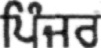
ਪਿੰਜਰ
